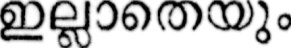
ഇല്ലാതെയും
